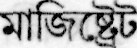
মাজিষ্ট্রেট
